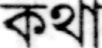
কথা
